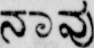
ನಾವು
